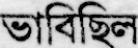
ভাবিছিল
